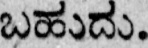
ಬಹುದು.
